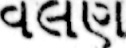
વલણ
